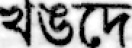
খঙদে
